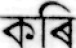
কৰি
